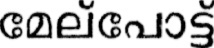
മേല്പോട്ട്
